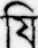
যি
